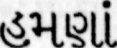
હમણાં
